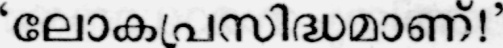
'ലോകപ്രസിദ്ധമാണ്!'
